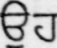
ਉਹ
